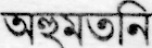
অহুমতনি
